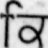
ਕਿ
